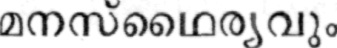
മനസ്ഥൈര്യവും
